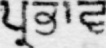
ਪ੍ਰਭਾਵ
